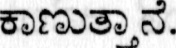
ಕಾಣುತ್ತಾನೆ.
